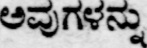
ಅವುಗಳನ್ನು
